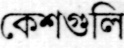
কেশগুলি
